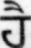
ਹੈ
